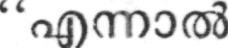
"എന്നാല്‍
